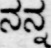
ನನ್ನ
